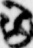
છે
